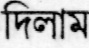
দিলাম
